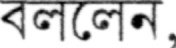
বললেন,
